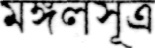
মঙ্গলসূত্র
